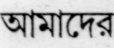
আমাদের
